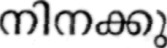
നിനക്കു
